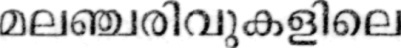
മലഞ്ചരിവുകളിലെ
